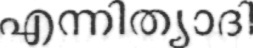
എന്നിത്യാദി
